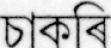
চাকৰি
